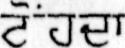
ਟੋਂਹਦਾ
